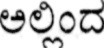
ಅಲ್ಲಿಂದ
